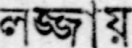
লজ্জায়
